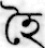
হৈ
